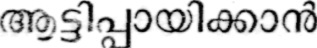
ആട്ടിപ്പായിക്കാന്‍
